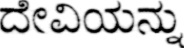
ದೇವಿಯನ್ನು
